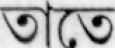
তাতে
